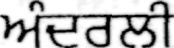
ਅੰਦਰਲੀ
